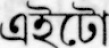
এইটো
